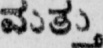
ಮತ್ತು
